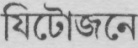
যিটোজনে
